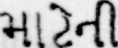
માટેની
